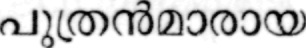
പുത്രന്‍മാരായ
